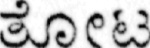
ತೋಟ
